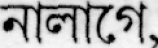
নালাগে,
